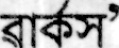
ৱার্কস’
